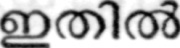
ഇതില്‍
